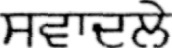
ਸਵਾਦਲੇ
